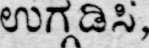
ಉಗ್ಗಡಿಸಿ,
